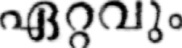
ഏറ്റവും
